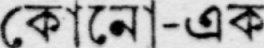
কোনো-এক
